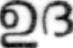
ഉദ
